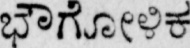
ಭೌಗೋಳಿಕ
